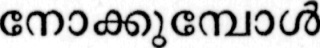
നോക്കുമ്പോള്‍
